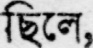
ছিলে,
